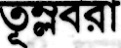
তূম্লবরা
